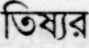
তিষ্যর
